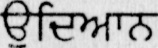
ਉਦਿਆਨ
